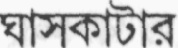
ঘাসকাটার
